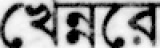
খেন্নরে
